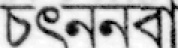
চৎননবা
